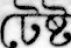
টেষ্ট
